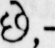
છે,-
